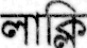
লাক্লি
